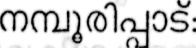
നമ്പൂരിപ്പാട്:
